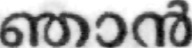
ഞാന്‍
